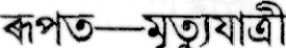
ৰূপত-মৃত্যুযাত্রী
